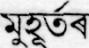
মুহূর্তৰ
